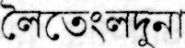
লৈতেংলদুনা
